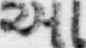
આ
